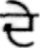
ਦੇ
